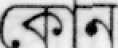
কোন
